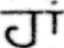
ਹਾਂ
